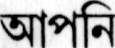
আপনি
